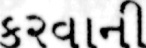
કરવાની
